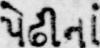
પેઢીનાં
